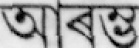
আৰম্ভ
